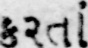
કરતાં
